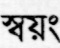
স্বয়ং
